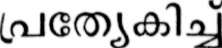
പ്രത്യേകിച്ച്
